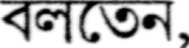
বলতেন,
